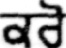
ਕਰੋ
